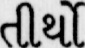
તીર્થો
